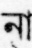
না
